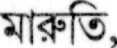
মারুতি,
